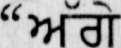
''ਅੱਗੇ
